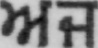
ਅਜ
